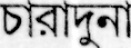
চারাদুনা
